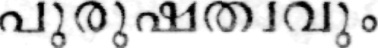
പുരുഷത്വവും
